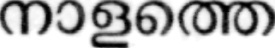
നാളത്തെ
